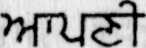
ਆਪਣੀ
